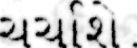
ચર્ચાશે.
